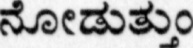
ನೋಡುತ್ತುಂ
